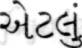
એટલું
